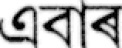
এবাৰ
